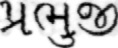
પ્રભુજી
